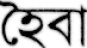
হৈবা
